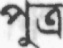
পুত্র
